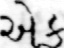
એક
